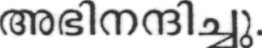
അഭിനന്ദിച്ചു.
